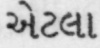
એટલા
